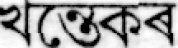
খন্তেকৰ
